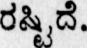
ರಷ್ಟಿದೆ.
